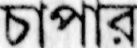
চাপার
